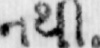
નથી.
